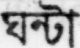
ঘন্টা
